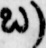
ಬ)
